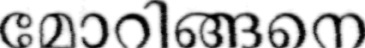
മോറിങ്ങനെ
